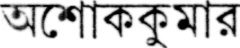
অশোককুমার
